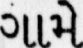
ગામે
